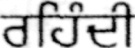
ਰਹਿੰਦੀ
